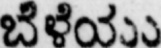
ಬೆಳೆಯು
